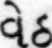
વેઠ
